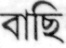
বাছি
